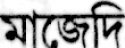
মাজেদি
